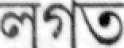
লগত
